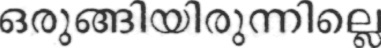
ഒരുങ്ങിയിരുന്നില്ലെ
